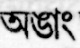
অঙাং
